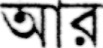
আর
